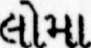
લોમા
